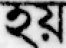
হয়
